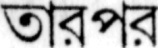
তারপর
